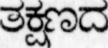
ತಕ್ಷಣದ
